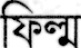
ফিল্ম
